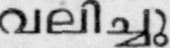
വലിച്ചു
